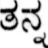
ತನ್ನ
